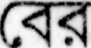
বের
